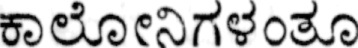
ಕಾಲೋನಿಗಳಂತೂ
